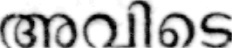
അവിടെ
